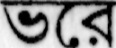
ভরে
